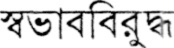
স্বভাববিরুদ্ধ
